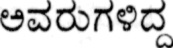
ಅವರುಗಳಿದ್ದ
